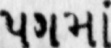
પગમાં
